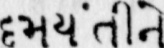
દમયંતીને
